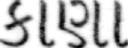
કાણા
